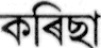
কৰিছা
